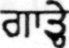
ਗਾੜ੍ਹੇ
